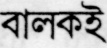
বালকই
